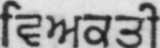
ਵਿਅਕਤੀ
